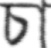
চা
